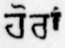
ਹੋਰਾਂ
